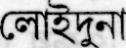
লোইদুনা
